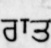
ਰਾਤ
